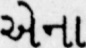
એના
